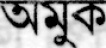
অমুক
